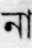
না
